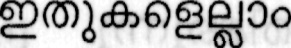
ഇതുകളെല്ലാം
